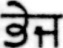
ਭੇਜ
